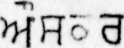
ਔਸਕਰ
